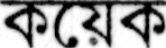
কয়েক
